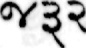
જરૂર
